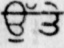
ਉੱਤੇ
